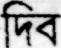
দিব
